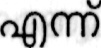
എന്ന്
